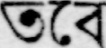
তবে
